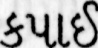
કપાઈ
